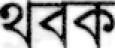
থবক
